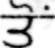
ਤੋਂ
